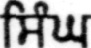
ਸਿੰਘ
